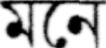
মনে
